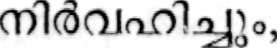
നിര്‍വഹിച്ചും,
